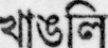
খাঙলি
